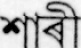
শাৰী
